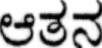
ಆತನ
